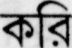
করি
